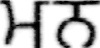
ਮਨ
